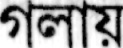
গলায়
